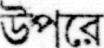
উপরে
